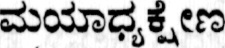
ಮಯಾಧ್ಯಕ್ಷೇಣ
